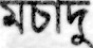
মচাদু
